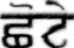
ਛੋਟੇ
